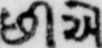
છીએ
